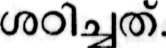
ശഠിച്ചത്.
